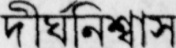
দীর্ঘনিশ্বাস
